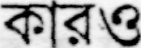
কারও
